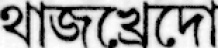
থাজখ্রেদো
